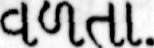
વળતા.
